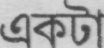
একটা
